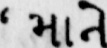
'માને
